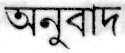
অনুবাদ
